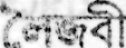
লৈজবী
